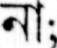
না;
